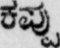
ಕಪ್ಪು
